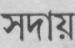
সদায়
